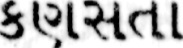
કણસતા
